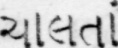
ચાલતાં
